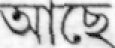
আছে
